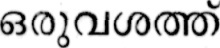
ഒരുവശത്ത്
